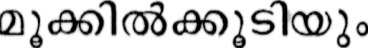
മൂക്കില്‍ക്കൂടിയും
